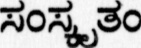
ಸಂಸ್ಕೃತ೦
